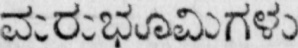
ಮರುಭೂಮಿಗಳು
